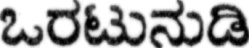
ಒರಟುನುಡಿ
